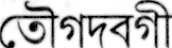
তৌগদবগী
